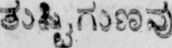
ತುಷ್ಟಿಗುಣವು
